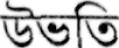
উভতি
